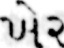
ખેર
